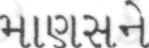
માણસને
